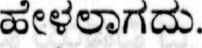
ಹೇಳಲಾಗದು.
